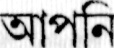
আপনি
